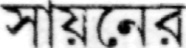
সায়নের
